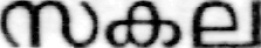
സകല
